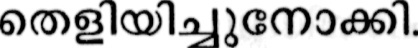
തെളിയിച്ചുനോക്കി.
